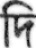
দি
